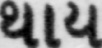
થાય
